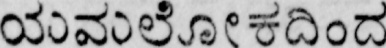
ಯಮಲೋಕದಿಂದ
